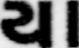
યા
